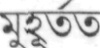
মুহূর্তত
